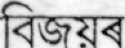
বিজয়ৰ
